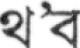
থ'ব
